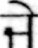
ਜੇ
